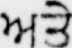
ਅਤੇ
